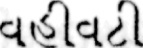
વહીવટી
